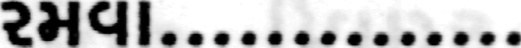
રમવા.................
